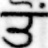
ਤੋਂ
